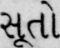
સૂતો
